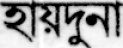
হায়দুনা
